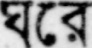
ঘরে
